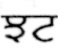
ਝਟ
